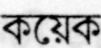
কয়েক
